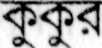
কুকুর
